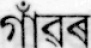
গাঁৱৰ
